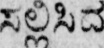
ಸಲ್ಲಿಸಿದ
